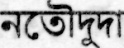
নতৌদুদা
